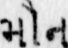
મૌન
